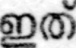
ഇത്
